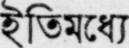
ইতিমধ্যে
